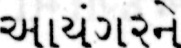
આયંગરને
